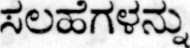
ಸಲಹೆಗಳನ್ನು
